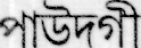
পাউদগী
